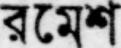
রমেশ
